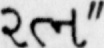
રત્ન"
